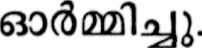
ഓര്‍മ്മിച്ചു.
